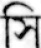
সি
